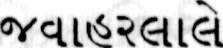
જવાહરલાલે
